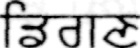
ਡਿਗਣ
